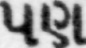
પણ
